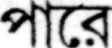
পারে
